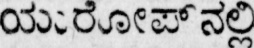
ಯುರೋಪ್‌ನಲ್ಲಿ
